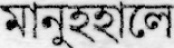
মানুহহালে
